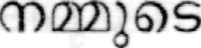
നമ്മുടെ
